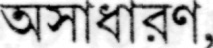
অসাধারণ,
